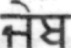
ਜੇਬ
